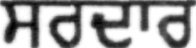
ਸਰਦਾਰ
